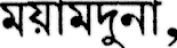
ময়ামদুনা,
